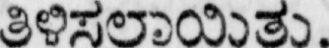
ತಿಳಿಸಲಾಯಿತು.
